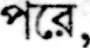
পরে,
